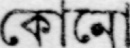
কোনো
